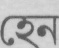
হেন
